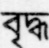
বৃদ্ধ
